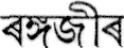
ৰঙ্গজীৰ
